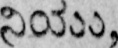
ನಿಯು,
